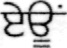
ਏਊਂ
